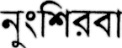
নুংশিরবা
